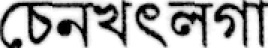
চেনখৎলগা
